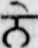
ਨੇ
